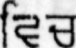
ਵਿਚ
